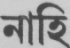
নাহি
